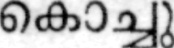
കൊച്ചു
